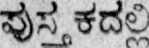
ಪುಸ್ತಕದಲ್ಲಿ
